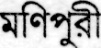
মণিপুরী
